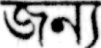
জন্য
